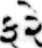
ફરે
